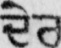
ਦੇਰ
